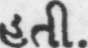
હતી.
